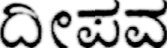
ದೀಪವ
